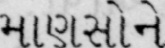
માણસોને
